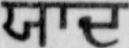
ਯਾਦ
